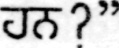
ਹਨ?''
